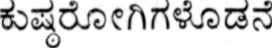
ಕುಷ್ಠರೋಗಿಗಳೊಡನೆ
